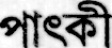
পাৎকী
